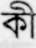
কী
